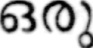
ഒരു
